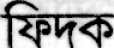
ফিদক
